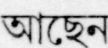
আছেন
